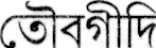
তৌবগীদি
